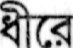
ধীরে
